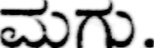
ಮಗು.
